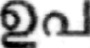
ഉപ
